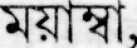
ময়াম্বা,
